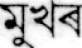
মুখৰ
